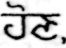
ਹੋਣ,
